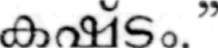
കഷ്ടം."
